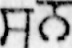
ਸਨ
